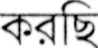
করছি
